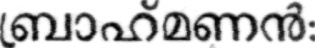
ബ്രാഹ്മണന്‍:
